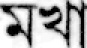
মখা
